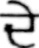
ਦੇ
